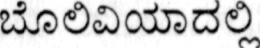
ಬೊಲಿವಿಯಾದಲ್ಲಿ
